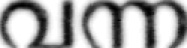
വന്ന
